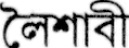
লৈশাবী
